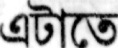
এটাতে
